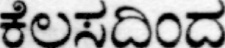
ಕೆಲಸದಿಂದ
